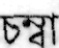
চম্বা
